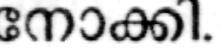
നോക്കി.
